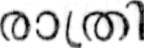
രാത്രി
